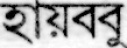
হায়ববু
